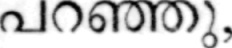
പറഞ്ഞു,
